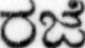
ರಜೆ
